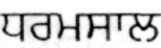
ਧਰਮਸਾਲ
